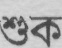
শুক
